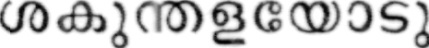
ശകുന്തളയോടു
